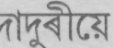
দাদুৰীয়ে
